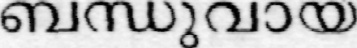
ബന്ധുവായ
